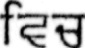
ਵਿਚ
